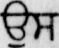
ਉਸ
